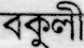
বকুলী
